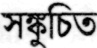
সঙ্কুচিত
